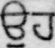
ਉਹ
